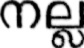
നല്ല
